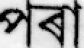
পৰা
